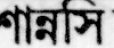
শান্নসি
